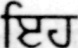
ਇਹ
